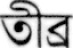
তীব্র
